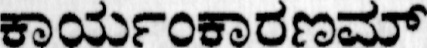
ಕಾರ್ಯಂಕಾರಣಮ್
